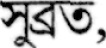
সুব্রত,
